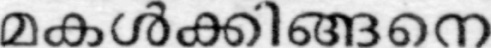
മകള്‍ക്കിങ്ങനെ
